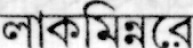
লাকমিন্নরে
